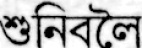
শুনিবলৈ
